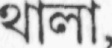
থালা,
